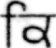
ਕਿ
